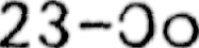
23-ാം
